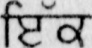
ਇੱਕ
